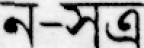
ন-সত্র
